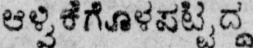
ಆಳ್ವಿಕೆಗೊಳಪಟ್ಟಿದ್ದ
